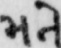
મને
